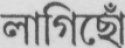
লাগিছোঁ
